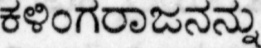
ಕಳಿಂಗರಾಜನನ್ನು
